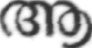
ആ
